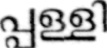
പ്പള്ളി
